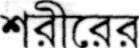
শরীরের
